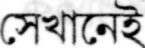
সেখানেই
